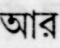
আর
